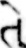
તે
